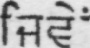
ਜਿਵੇਂ
